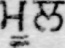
ਮੂਲ
